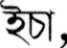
ইচা,
